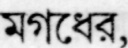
মগধের,
